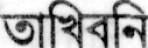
তাখিবনি
